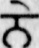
ਨੇ
